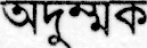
অদুম্মক
